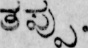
ತಪ್ಪು.
